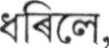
ধৰিলে,
